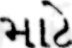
માટે
